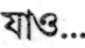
যাও...
